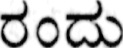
ರಂದು
